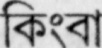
কিংবা
